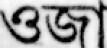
ওজা
